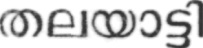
തലയാട്ടി
